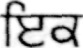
ਇਕ
